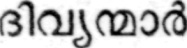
ദിവ്യന്മാര്‍
